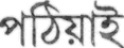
পঠিয়াই
